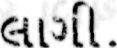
લાગી.
